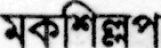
মকশিল্লপ
